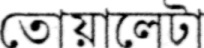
তোয়ালেটা
